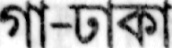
গা-ঢাকা
